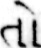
તો
